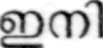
ഇനി
